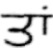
ਤਾਂ
